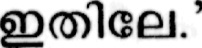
ഇതിലേ.’
